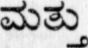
ಮತ್ತು
